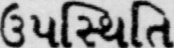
ઉપસ્થિતિ
